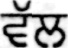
ਵੱਲ
